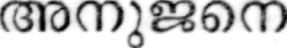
അനുജനെ
